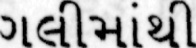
ગલીમાંથી
